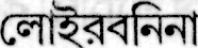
লোইরবনিনা
